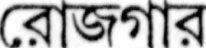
রোজগার
